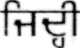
ਜਿਦ੍ਹੀ
